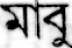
মাবু
